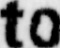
to
